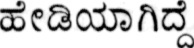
ಹೇಡಿಯಾಗಿದ್ದೆ
